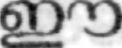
ഈ
